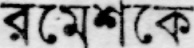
রমেশকে
